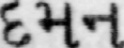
દમન
